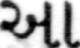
આ
